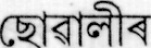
ছোৱালীৰ
